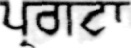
ਪ੍ਰਗਟਾ
